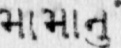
મામાનું
